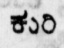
ಕುರಿ
